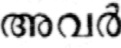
അവര്‍
